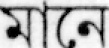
মানে
